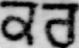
ਕਰ
